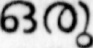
ഒരു
